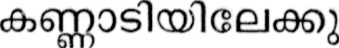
കണ്ണാടിയിലേക്കു
